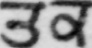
ਤਕ
